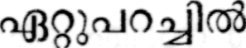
ഏറ്റുപറച്ചില്‍
